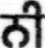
ਨੀ
